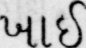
ખાઈ
